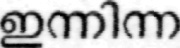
ഇന്നിന്ന
